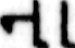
ના
